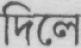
দিলে
